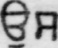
ਉਸ
